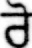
ਰੋ
